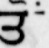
ਤੋਂ
